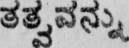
ತತ್ವವನ್ನು
